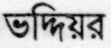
ভদ্দিয়র
